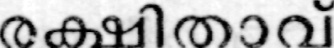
രക്ഷിതാവ്
